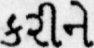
કરીને
